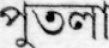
পুতলা
